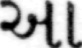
આ
